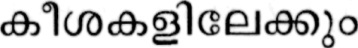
കീശകളിലേക്കും
